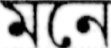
মনে
